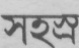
সহস্ৰ
